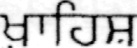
ਖ਼ਾਹਿਸ਼
